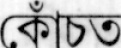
কোঁচত
